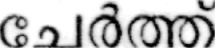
ചേര്‍ത്ത്
